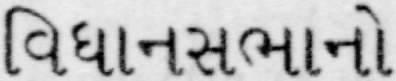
વિધાનસભાનો
